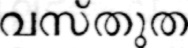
വസ്തുത
